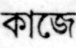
কাজে
